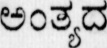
ಅಂತ್ಯದ
